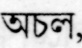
অচল,
